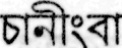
চানীংবা
